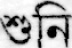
শুনি
